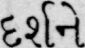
દર્શને
